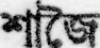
শাজৈ
